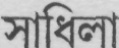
সাধিলা
